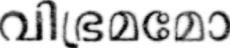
വിഭ്രമമോ
